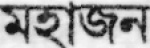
মহাজন
